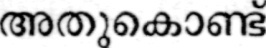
അതുകൊണ്ട്
